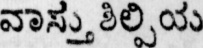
ವಾಸ್ತುಶಿಲ್ಪಿಯ
